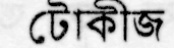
টোকীজ
